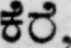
ಕೆರೆ,
